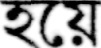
হয়ে
